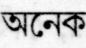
অনেক
